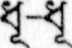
ধূ-ধূ
